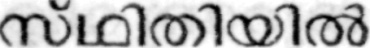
സ്ഥിതിയില്‍
